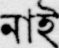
নাই
